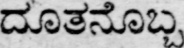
ದೂತನೊಬ್ಬ
